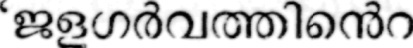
'ജളഗര്‍വത്തിന്റെ
